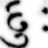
દુ:
